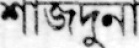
শাজদুনা
